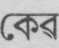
কেৱ
